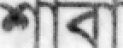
শাবা
